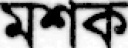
মশক
